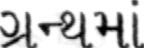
ગ્રન્થમાં
